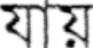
যায়
